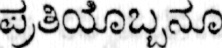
ಪ್ರತಿಯೊಬ್ಬನೂ
